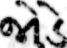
જોડે
